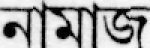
নামাজ
